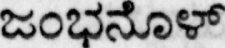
ಜಂಭನೊಳ್
